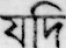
যদি
